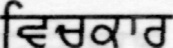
ਵਿਚਕਾਰ
